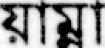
য়াম্না
